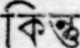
কিন্তু
